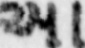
આ
